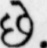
છે.
